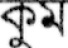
কুম
